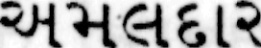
અમલદાર
